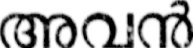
അവന്‍
